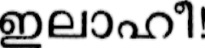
ഇലാഹീ!
